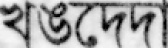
খঙদেদা
